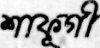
শাফূগী
